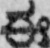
ಈ
